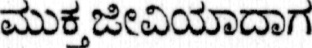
ಮುಕ್ತಜೀವಿಯಾದಾಗ
